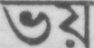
ভয়
